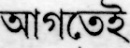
আগতেই
